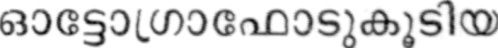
ഓട്ടോഗ്രാഫോടുകൂടിയ
